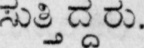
ಸುತ್ತಿದ್ದರು.
